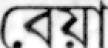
বেয়া
